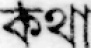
কথা
